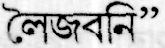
লৈজবনি”
